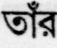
তাঁর
